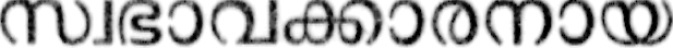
സ്വഭാവക്കാരനായ
